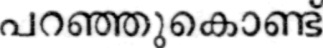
പറഞ്ഞുകൊണ്ട്
